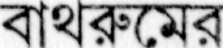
বাথরুমের
